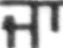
ਜਾ
